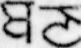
ਬਣ
